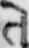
તે
